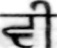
ਵੀ
